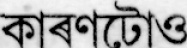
কাৰণটোও
